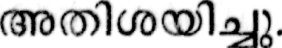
അതിശയിച്ചു.
